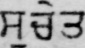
ਸੁਚੇਤ
